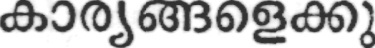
കാര്യങ്ങളെക്കു
